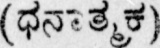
(ಧನಾತ್ಮಕ)
